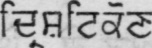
ਦ੍ਰਿਸ਼ਟਿਕੋਣ
